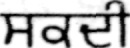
ਸਕਦੀ
